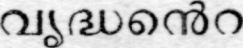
വൃദ്ധന്റെ
